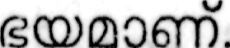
ഭയമാണ്.
